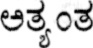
ಅತ್ಯಂತ
